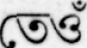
তেওঁ
